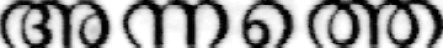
അന്നത്തെ
